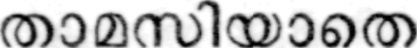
താമസിയാതെ
